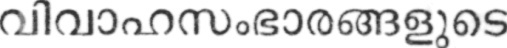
വിവാഹസംഭാരങ്ങളുടെ
